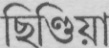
ছিণ্ডিয়া
